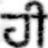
ਹੀ
